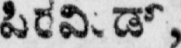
ಪಿರಮಿಡ್,
